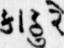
કાઠુરે
